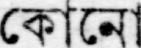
কোনো
